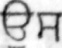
ਉਸ
